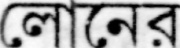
লোনের
